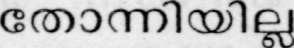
തോന്നിയില്ല
